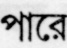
পারে
